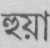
হুয়া
